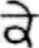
ਕੇ
